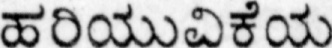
ಹರಿಯುವಿಕೆಯ
